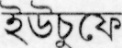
ইউচুফে
